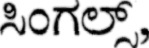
ಸಿಂಗಲ್ಸ್,
